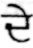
ਦੇ
